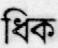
ধিক
